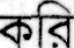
করি
